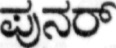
ಪುನರ್
